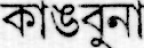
কাঙবুনা
